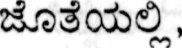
ಜೊತೆಯಲ್ಲಿ,
